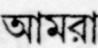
আমরা
